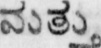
ಮತ್ತು
